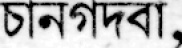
চানগদবা,
